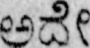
ಅದೇ
